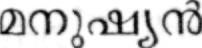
മനുഷ്യന്‍
